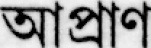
আপ্রাণ
